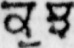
ਕੁਝ
